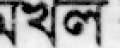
মখল
